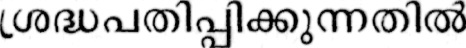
ശ്രദ്ധപതിപ്പിക്കുന്നതില്‍
